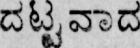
ದಟ್ಟವಾದ
